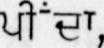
ਪੀਂਦਾ,
